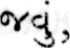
જવું,
